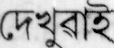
দেখুৱাই
